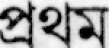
প্রথম
